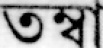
তম্বা
